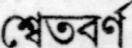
শ্বেতবর্ণ
